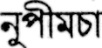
নুপীমচা
